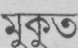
মুকুত
